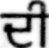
ਦੀ
